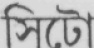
সিটো
